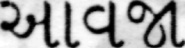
આવજા
